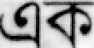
এক
